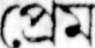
প্রেম
